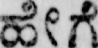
ಹೇಗೆ
